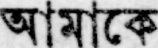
আমাকে
